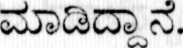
ಮಾಡಿದ್ದಾನೆ.
